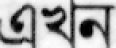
এখন
